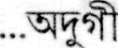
...অদুগী
